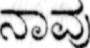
ನಾವು
